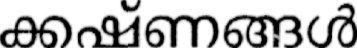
ക്കഷ്ണങ്ങള്‍
